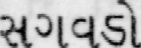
સગવડો
